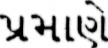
પ્રમાણે
